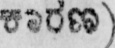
ಕಾರಣ)
